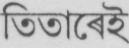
তিতাৰেই
